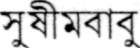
সুষীমবাবু
